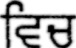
ਵਿਚ
